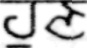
ਹੁਣ
